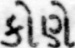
કોણે
